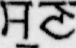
ਸੁਣ
